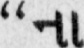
"ના
